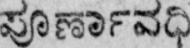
ಪೂರ್ಣಾವಧಿ
